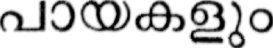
പായകളും
